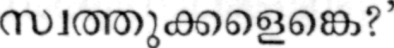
സ്വത്തുക്കളെങ്കെ?'
